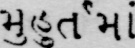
મુહુર્તમાં
